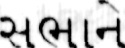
સભાને
